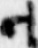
ન
